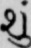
શું
